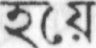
হয়ে
